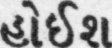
હોઈશ
